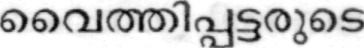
വൈത്തിപ്പട്ടരുടെ
